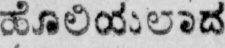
ಹೊಲಿಯಲಾದ
